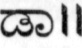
ಡಾ||
